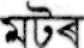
মটৰ
